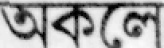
অকলে
